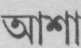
আশা
